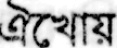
ঐখোয়
